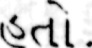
હતો.
